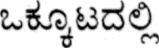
ಒಕ್ಕೂಟದಲ್ಲಿ
